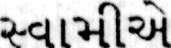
સ્વામીએ
